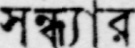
সন্ধ্যার
